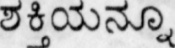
ಶಕ್ತಿಯನ್ನೂ
